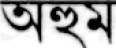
অহুম
